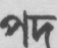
পদ
